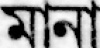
মানা
